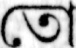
তো
